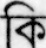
কি
